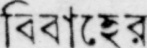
বিবাহের
